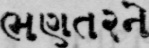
ભણતરને
